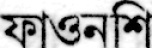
ফাওনশি
